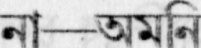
না-অমনি
